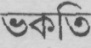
ভকতি
